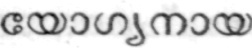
യോഗ്യനായ
